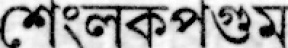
শেংলকপগুম
